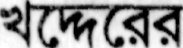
খদ্দেরের
